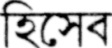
হিসেব
